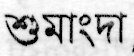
শুমাংদা
